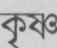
কৃষ্ণ
